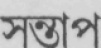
সন্তাপ
